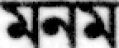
মনম
